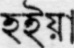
হইয়া
